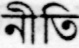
নীতি
